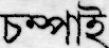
চম্পাই
